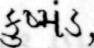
કુષ્મંડ,
